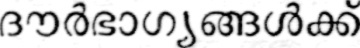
ദൌര്‍ഭാഗ്യങ്ങള്‍ക്ക്
